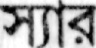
স্যার
